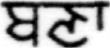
ਬਣਾ
